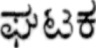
ಘಟಕ
